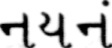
નયનં
